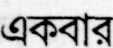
একবার
